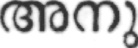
അനു
